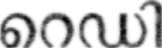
റെഡി
